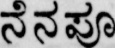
ನೆನಪೂ
